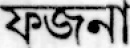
ফজনা
